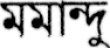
মমান্দু
